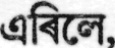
এৰিলে,
